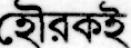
হৌরকই
